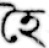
হৈ
